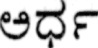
ಅರ್ಧ
